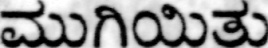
ಮುಗಿಯಿತು
